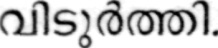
വിടുര്‍ത്തി.
